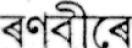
ৰণবীৰে
